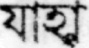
যাহা
